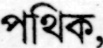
পথিক,
